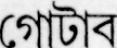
গোটাব
